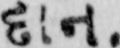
દાન.
